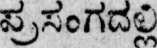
ಪ್ರಸಂಗದಲ್ಲಿ
